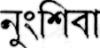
নুংশিবা
